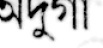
অদুগা
